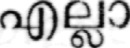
എല്ലാ
